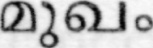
മുഖം
